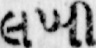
લખી
